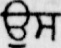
ਉਸ
